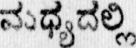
ಮಧ್ಯದಲ್ಲಿ
